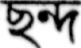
ছন্দ
